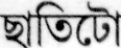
ছাতিটো
